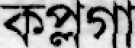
কপ্লগা
